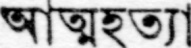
আত্মহত্যা
